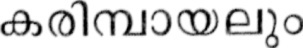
കരിമ്പായലും
